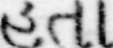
હતા
